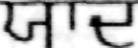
ਯਾਦ
